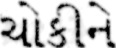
ચોકીને
